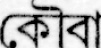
কৌবা
